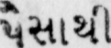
પૈસાથી
